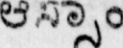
ಅಸ್ಸಾಂ
